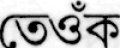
তেওঁক
